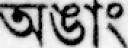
অঙাং
